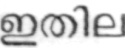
ഇതില
